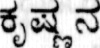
ಕೃಷ್ಣನ
